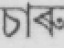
চাৰু
